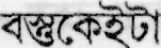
বস্তুকেইটা
